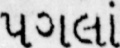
પગલાં
